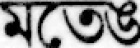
মতেঙ
